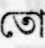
তো
